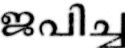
ജപിച്ച
